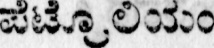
ಪೆಟ್ರೊಲಿಯಂ
